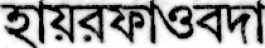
হায়রফাওবদা
